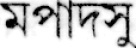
মপাদসু
